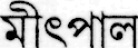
মীৎপাল
